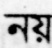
নয়
